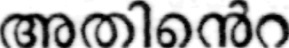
അതിന്റെ
